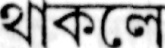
থাকলে
